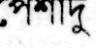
পৈশাদু
